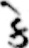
કે
